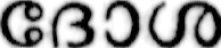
ദോശ
